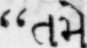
"તમે
